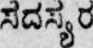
ಸದಸ್ಯರ
